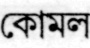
কোমল
